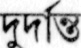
দুর্দান্ত
